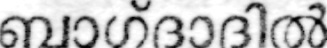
ബാഗ്ദാദില്‍
